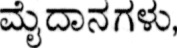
ಮೈದಾನಗಳು,
